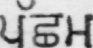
ਪੱਛਮ
